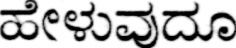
ಹೇಳುವುದೂ
